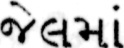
જેલમાં
